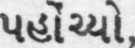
પહોંચ્યો,
